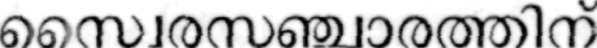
സ്വൈരസഞ്ചാരത്തിന്
